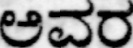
ಅವರ
